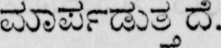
ಮಾರ್ಪಡುತ್ತದೆ.
